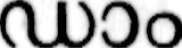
ഡാം
